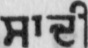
ਸਾਦੀ
